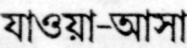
যাওয়া-আসা
